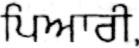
ਪਿਆਰੀ,
